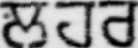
ਲਹਰ
